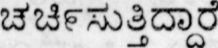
ಚರ್ಚಿಸುತ್ತಿದ್ದಾರೆ
